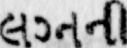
લગ્નની
